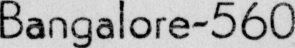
Bangalore-560
